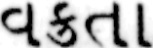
વક્રતા
